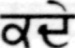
ਕਦੇ
